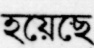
হয়েছে
